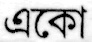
একো
